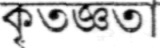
কৃতজ্ঞতা
